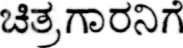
ಚಿತ್ರಗಾರನಿಗೆ
